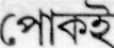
পোকই
